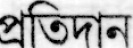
প্রতিদান
